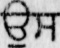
ਉਸ
